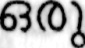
ഒരു
